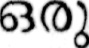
ഒരു
